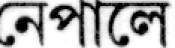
নেপালে
